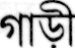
গাড়ী
